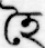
হৈ
